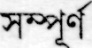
সম্পূর্ণ
